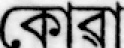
কোৱা
